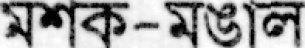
মশক-মঙাল
